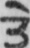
ਤੇ
